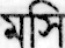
মসি
